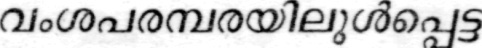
വംശപരമ്പരയിലുള്‍പ്പെട്ട
